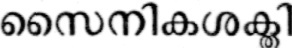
സൈനികശക്തി
